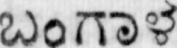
ಬಂಗಾಳ
